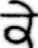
ਕੇ
